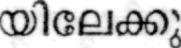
യിലേക്കു
